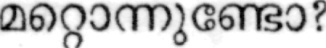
മറ്റൊന്നുണ്ടോ?
